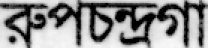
রুপচন্দ্রগা
